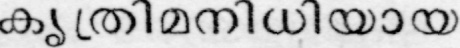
കൃത്രിമനിധിയായ
